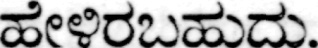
ಹೇಳಿರಬಹುದು.
